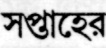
সপ্তাহের
